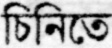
চিনিতে
